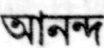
আনন্দ
